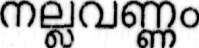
നല്ലവണ്ണം
